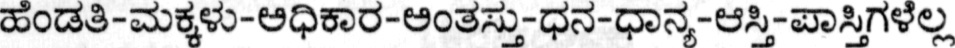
ಹೆ೦ಡತಿ-ಮಕ್ಕಳು-ಅಧಿಕಾರ-ಅ೦ತಸ್ತು-ಧನ-ಧಾನ್ಯ-ಆಸ್ತಿ-ಪಾಸ್ತಿಗಳೆಲ್ಲ
